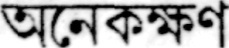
অনেকক্ষণ
